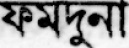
ফমদুনা
